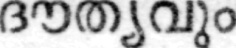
ദൌത്യവും
